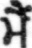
ਮੈਂ
